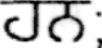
ਹਨ;
